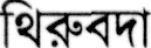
থিরুবদা
